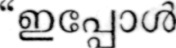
"ഇപ്പോള്‍
